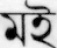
মই
